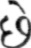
છે
